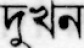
দুখন
